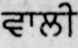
ਵਾਲੀ
